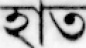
হাত
